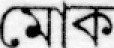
মোক
